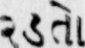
રડતો
